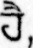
ਹੈ,
